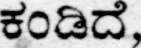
ಕಂಡಿದೆ,
